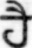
ਹੈ
